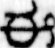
ಈ
